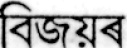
বিজয়ৰ
